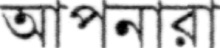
আপনারা
